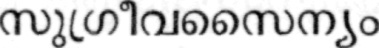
സുഗ്രീവസൈന്യം
